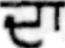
ਦਾ
